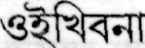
ওইখিবনা
